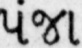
પંજા
